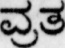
ವ್ರತ
